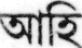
আহি
